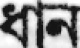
ধান
